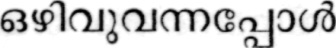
ഒഴിവുവന്നപ്പോള്‍
